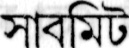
সাবমিট
